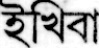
ইখিবা
